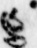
હું
